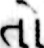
તો
